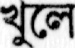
খুলে
